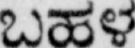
ಬಹಳ
